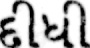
દીધી
